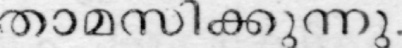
താമസിക്കുന്നു.
